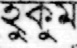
হুকুম
